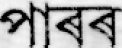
পাৰৰ
